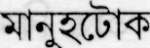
মানুহটোক
